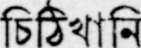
চিঠিখানি
